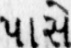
પાસે
